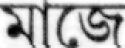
মাজে
